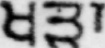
ਖੜਾ
